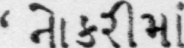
'નોકરીમાં
